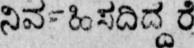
ನಿರ್ವಹಿಸದಿದ್ದರೆ
